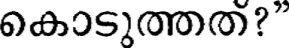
കൊടുത്തത്?"
